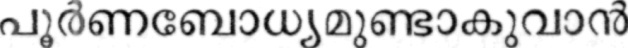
പൂര്‍ണബോധ്യമുണ്ടാകുവാന്‍
